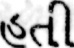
હતી
